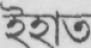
ইহাত
